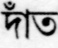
দাঁত
